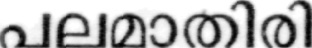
പലമാതിരി
